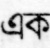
এক
